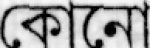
কোনো
